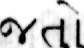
જતો
